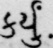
કર્યું.
